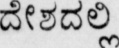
ದೇಶದಲ್ಲಿ
